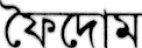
ফৈদোম
